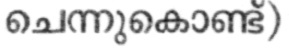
ചെന്നുകൊണ്ട്)
